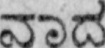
ವಾದ
